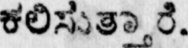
ಕಲಿಸುತ್ತಾರೆ.
